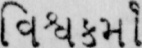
વિશ્વકર્મા
